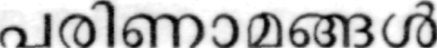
പരിണാമങ്ങള്‍
